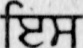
ਇਸ
